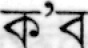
ক'ব
